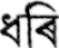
ধৰি
